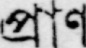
প্রাণ
